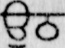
ਉਠ
